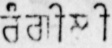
ਰੰਗੀਲੀ
